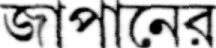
জাপানের
